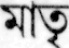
মাতৃ
